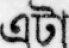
এটা
